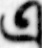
এ
